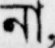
না,
